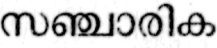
സഞ്ചാരിക
